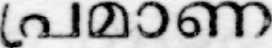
പ്രമാണ
